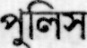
পুলিস
